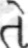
તે
